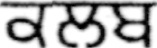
ਕਲਬ
